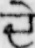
ਦੇ
